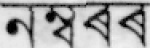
নম্বৰৰ
